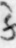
કે
